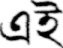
এই
